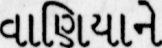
વાણિયાને
